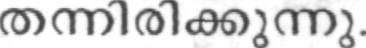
തന്നിരിക്കുന്നു.
